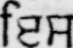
ਇਸ
